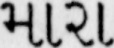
મારા
